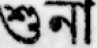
শুনা
